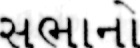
સભાનો
